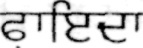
ਫ਼ਾਇਦਾ
